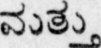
ಮತ್ತು
